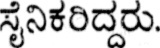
ಸೈನಿಕರಿದ್ದರು.
